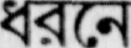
ধরনে
